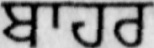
ਬਾਹਰ
